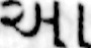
આ
